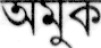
অমুক
